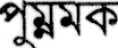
পুম্নমক
